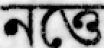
নত্তে
